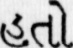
હતો
